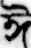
ঈ
